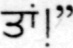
ਤਾਂ!''
